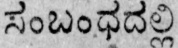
ಸಂಬಂಧದಲ್ಲಿ
